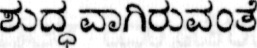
ಶುದ್ಧವಾಗಿರುವಂತೆ
